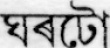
ঘৰটো
